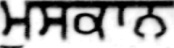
ਮੁਸਕਾਨ
